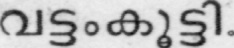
വട്ടംകൂട്ടി.
